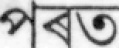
পৰত
